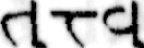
તત્વ
